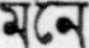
মনে
